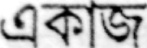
একাজ
